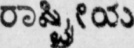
ರಾಷ್ಟ್ರೀಯ
